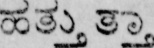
ಹತ್ತುತ್ತಾ
